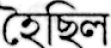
হৈছিল
